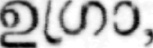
ഉഗ്രാ,
